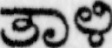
ತಾಳಿ
